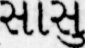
સાસુ
